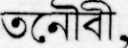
তনৌবী,
